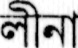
লীনা
